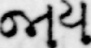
જાય
